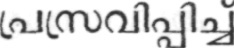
പ്രസ്രവിപ്പിച്ച്
